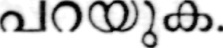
പറയുക.
